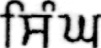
ਸਿੰਘ
